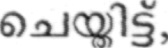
ചെയ്തിട്ട്,
